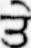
ਤੇ
